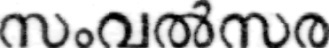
സംവല്‍സര
